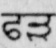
ਫੜ
